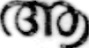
ആ
